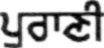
ਪੁਰਾਣੀ
